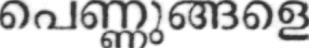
പെണ്ണുങ്ങളെ
